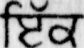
ਇੱਕ
